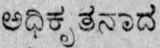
ಅಧಿಕೃತನಾದ
